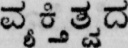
ವ್ಯಕ್ತಿತ್ವದ
